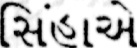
સિંહાએ
